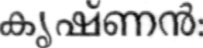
കൃഷ്ണന്‍:
